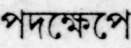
পদক্ষেপে
